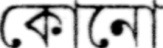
কোনো
